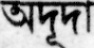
অদূদা
